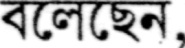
বলেছেন,
